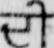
ਦੀ
